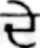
ਦੇ
